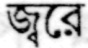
জ্বরে
